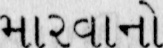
મારવાનો
